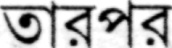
তারপর
